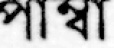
পাম্বা
